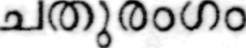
ചതുരംഗം
